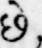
છે,
